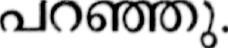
പറഞ്ഞു.
